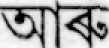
আৰু
